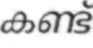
കണ്ട്
